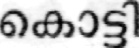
കൊട്ടി
